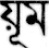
য়ূম
